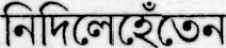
নিদিলেহেঁতেন
